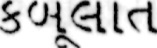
કબૂલાત
